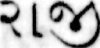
રાજી
